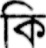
কি
